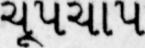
ચૂપચાપ
